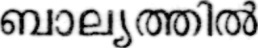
ബാല്യത്തില്‍
